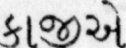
કાજીએ
